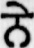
ਨੇ
